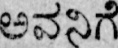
ಅವನಿಗೆ
